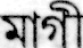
মাগী
